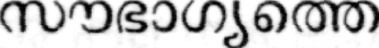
സൌഭാഗ്യത്തെ
